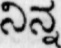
ನಿನ್ನ
